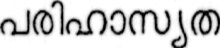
പരിഹാസ്യത
